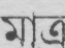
মাত্ৰ
